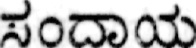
ಸಂದಾಯ
